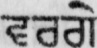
ਵਰਗੇ
